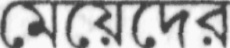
মেয়েদের
